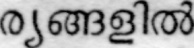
ര്യങ്ങളില്‍
